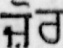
ਜ਼ੋਰ
